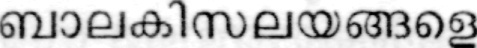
ബാലകിസലയങ്ങളെ
